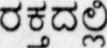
ರಕ್ತದಲ್ಲಿ
